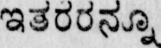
ಇತರರನ್ನೂ
